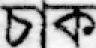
চাক
